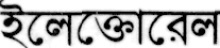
ইলেক্তোরেল
